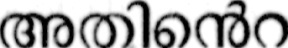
അതിന്റെ
